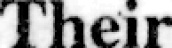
Their
